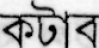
কটাব
